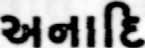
અનાદિ
